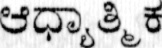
ಆಧ್ಯಾತ್ಮಿಕ
